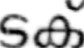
ടക്
